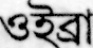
ওইব্রা
